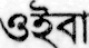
ওইবা
